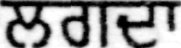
ਲਗਦਾ
